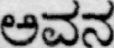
ಅವನ
